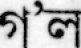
গ'ল
